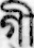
গী
